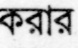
করার
